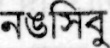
নঙসিবু
